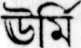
ঊর্মি
